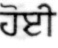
ਹੋਈ
